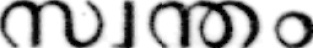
സ്വന്തം
